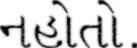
નહોતો.
